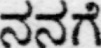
ನನಗೆ
